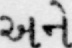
અને
